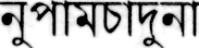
নুপামচাদুনা
